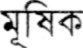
মূষিক
